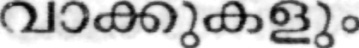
വാക്കുകളും
